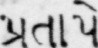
પ્રતાપે
